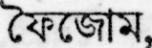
ফৈজোম,
